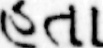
હતા
